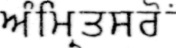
ਅੰਮ੍ਰਿਤਸਰੋਂ
